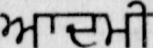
ਆਦਮੀ
